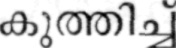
കുത്തിച്ച്
